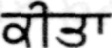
ਕੀਤਾ
